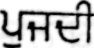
ਪੁਜਦੀ
